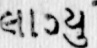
લાગ્યું
